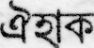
ঐহাক
